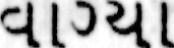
વાગ્યા
